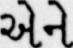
એને
